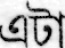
এটা
